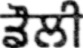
ਡੌਲੀ
